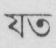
যত
